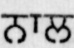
ਨਾਲ
